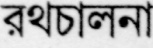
রথচালনা
